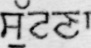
ਸੁੱਟਣਾ
